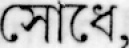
সোধে,
